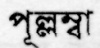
পূল্লম্বা
